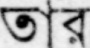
তার
